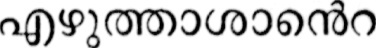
എഴുത്താശാന്റെ
